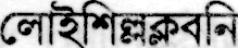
লৌইশিল্লক্লবনি
